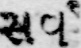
સર્વ
